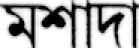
মশাদা
